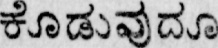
ಕೊಡುವುದೂ
